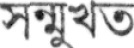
সন্মুখত
